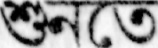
শুনতে
